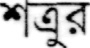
শত্রুর
